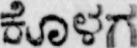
ಕೊಳಗ
